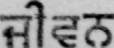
ਜੀਵਨ
